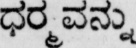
ಧರ್‍ಮವನ್ನು
